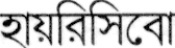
হায়রিসিবো
